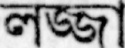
লজ্জা
